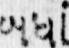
બધાં
